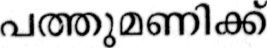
പത്തുമണിക്ക്
